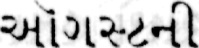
ઑગસ્ટની
